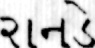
રાનડે
